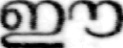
ഈ
